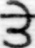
ਤੇ
